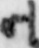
ન
